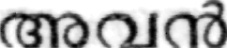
അവന്‍
